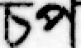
চপ
